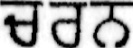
ਚਰਨ
